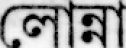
লোন্না
